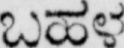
ಬಹಳ
